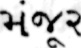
મંજૂર
